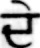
ਦੇ
